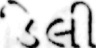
'ડેલી
